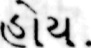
હોય.
